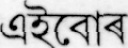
এইবোৰ
